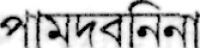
পামদবনিনা
